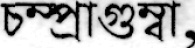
চম্প্রাগুম্বা,
